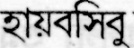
হায়বসিবু
